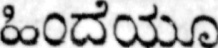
ಹಿಂದೆಯೂ
